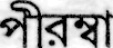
পীরম্বা
